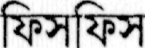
ফিসফিস
